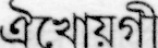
ঐখোয়গী
